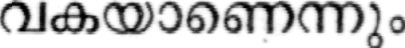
വകയാണെന്നും
